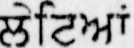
ਲੇਟਿਆਂ
